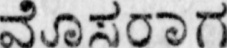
ಮೊಸರಾಗ
